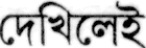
দেখিলেই
